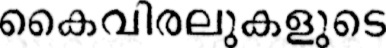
കൈവിരലുകളുടെ
